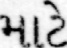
માટે
